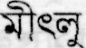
মীৎলু
